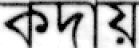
কদায়
